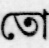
তো
